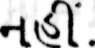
નહીં.
